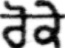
ਰੋਕੇ
